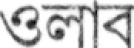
ওলাব
